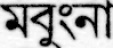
মবুংনা
